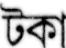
টকা
